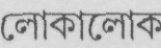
লোকালোক
